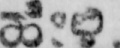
ಹೇಳಿ.
